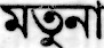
মতুনা
